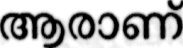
ആരാണ്
